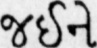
જઈને
